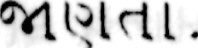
જાણતા.
